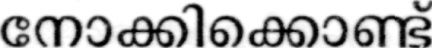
നോക്കിക്കൊണ്ട്
